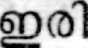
ഇരി
